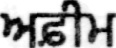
ਅਫ਼ੀਮ
